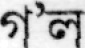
গ'ল
